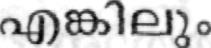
എങ്കിലും
